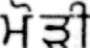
ਮੋੜੀ
